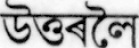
উত্তৰলৈ
